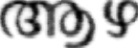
ആഴ
